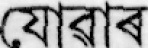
যোৱাৰ
